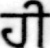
ਹੀ
